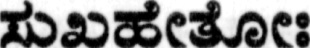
ಸುಖಹೇತೋಃ
